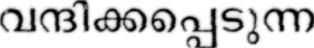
വന്ദിക്കപ്പെടുന്ന
